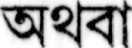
অথবা
